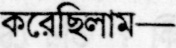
করেছিলাম–
